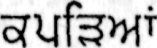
ਕਪੜਿਆਂ
